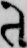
તે
